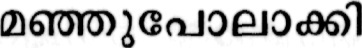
മഞ്ഞുപോലാക്കി
